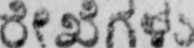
ರೇಖೆಗಳು
